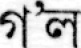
গ'ল
